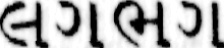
લગભગ
